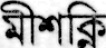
মীশক্নি
